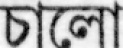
চালো
